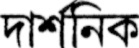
দার্শনিক
